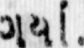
ગયાં.
